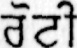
ਰੋਟੀ
